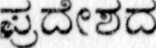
ಪ್ರದೇಶದ
